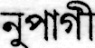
নুপাগী
